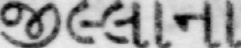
જીલ્લાના
